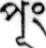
পূং
